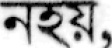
নহয়,
